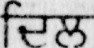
ਦਿਲ
